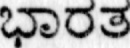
ಭಾರತ
